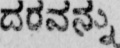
ದರವನ್ನು
